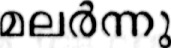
മലര്‍ന്നു
